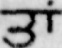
ਤਾਂ
